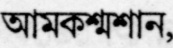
আমকশ্মশান,
